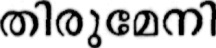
തിരുമേനി
